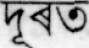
দূৰত
